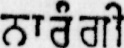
ਨਾਰੰਗੀ
